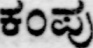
ಕಂಪು
